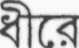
ধীরে
